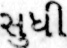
સુધી
